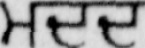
ਮਦਦ
